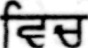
ਵਿਚ
